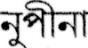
নুপীনা
